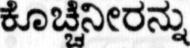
ಕೊಚ್ಚೆನೀರನ್ನು
